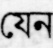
যেন
